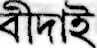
বীদাই
